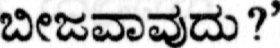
ಬೀಜವಾವುದು?’
